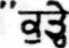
''ਕੁੜ੍ਹੇ
